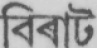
বিৰাট
